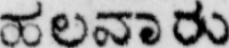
ಹಲವಾರು
